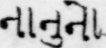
નાનુનો
